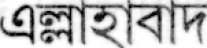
এল্লাহাবাদ
